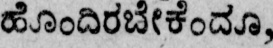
ಹೊಂದಿರಬೇಕೆಂದೂ,
